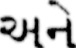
અને
